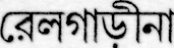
রেলগাড়ীনা
